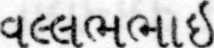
વલ્લભભાઈ
